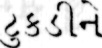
ટુકડીને
